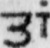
ਤਾਂ
